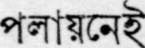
পলায়নেই
